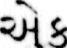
એક
